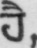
ਹੈ,
